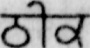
ਠੀਕ
